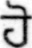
ਹੋ
